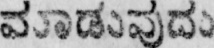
ಮಾಡುವುದು
